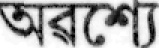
অৱশ্যে
